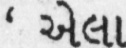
એલા
